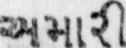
અમારી
